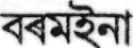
বৰমইনা
